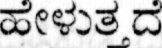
ಹೇಳುತ್ತದೆ
